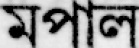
মপাল
